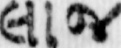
લાજ
